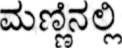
ಮಣ್ಣಿನಲ್ಲಿ
